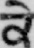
ਕੇ
